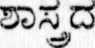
ಶಾಸ್ತ್ರದ
